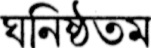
ঘনিষ্ঠতম
